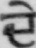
ਦੇ
